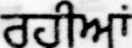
ਰਹੀਆਂ
